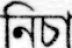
নিচা
